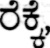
ರೆಕ್ಕೆ,
